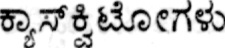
ಕ್ಯಾಸ್ಕ್ ಕ್ವಿಟೋಗಳು
